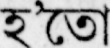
হ'তো
